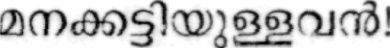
മനക്കട്ടിയുള്ളവന്‍!
